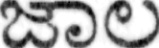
ಜಾಲ
